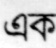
এক
